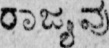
ರಾಜ್ಯವು
